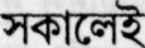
সকালেই
